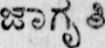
ಜಾಗೃತಿ
